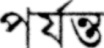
পর্যন্ত
